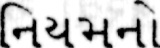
નિયમનો
